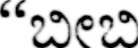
"ಬೀಬಿ
